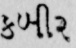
કબીર
